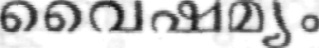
വൈഷമ്യം
